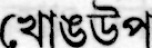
খোঙউপ
